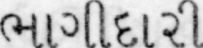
ભાગીદારી
